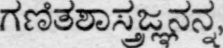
ಗಣಿತಶಾಸ್ತ್ರಜ್ಞನನ್ನ,
